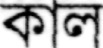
কাল
